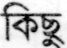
কিছু
